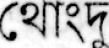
থোংদু
